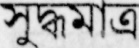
সুদ্ধমাত্র
